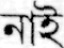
নাই
